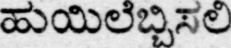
ಹುಯಿಲೆಬ್ಬಿಸಲಿ
